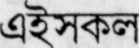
এইসকল
